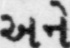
અને
